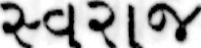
સ્વરાજ
